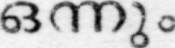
ഒന്നും
